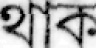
থাক
